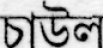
চাউল
